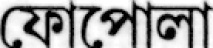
ফোপোলা
